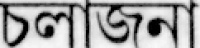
চলাজনা
